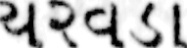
યરવડા
